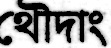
থৌদাং
